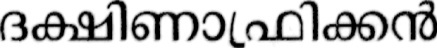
ദക്ഷിണാഫ്രിക്കന്‍
